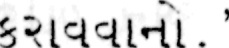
કરાવવાનો.
